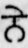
ਨੇ
